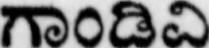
ಗಾಂಡಿವಿ
